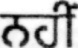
ਨਹੀਂ
